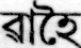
ৱাহৈ
